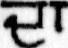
ਦਾ
